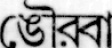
ঙৌরবা
